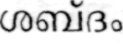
ശബ്ദം
